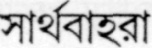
সার্থবাহরা
